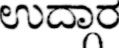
ಉದ್ಗಾರ
